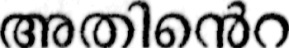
അതിന്റെ
